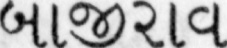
બાજીરાવ
